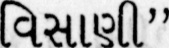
વિસાણી"
